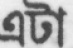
এটা
